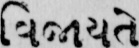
વિજાયતે
